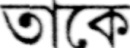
তাকে
